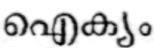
ഐക്യം
